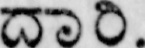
ದಾರಿ.
